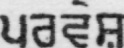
ਪਰਵੇਸ਼
